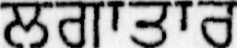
ਲਗਾਤਾਰ
